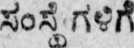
ಸಂಸ್ಥೆಗಳಿಗೆ
